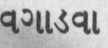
વગાડવા
